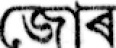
জোৰ
